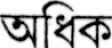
অধিক
